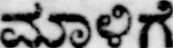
ಮಾಳಿಗೆ
